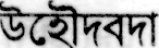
উহৌদবদা
